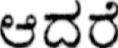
ಆದರೆ
